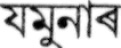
যমুনাৰ
